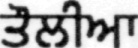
ਤੌਲੀਆ
